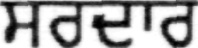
ਸਰਦਾਰ
